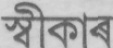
স্বীকাৰ
